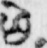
છે.
